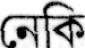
নেকি
